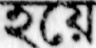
হয়ে
